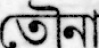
তৌনা
